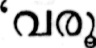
'വരൂ
